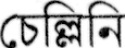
চেল্লিনি
